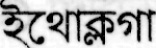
ইথোক্লগা
